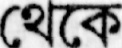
থেকে
